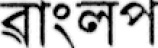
ৱাংলপ
